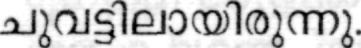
ചുവട്ടിലായിരുന്നു.
